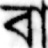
বা
